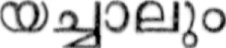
യച്ചാലും
